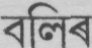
বলিৰ
